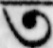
ত
